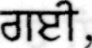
ਗਈ,
